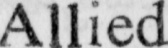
Allied
